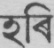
হৰি
